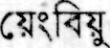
য়েংবিয়ু
